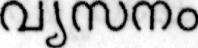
വ്യസനം
